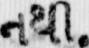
નથી.
